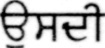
ਉਸਦੀ
